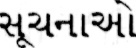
સૂચનાઓ
